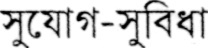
সুযোগ-সুবিধা
